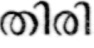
തിരി
